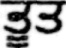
ਭੂਤ
